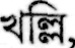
খল্লি,
